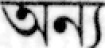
অন্য
